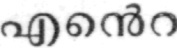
എന്റെ
